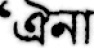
‘ঐনা
